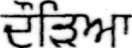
ਦੌੜਿਆ
